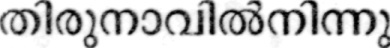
തിരുനാവില്‍നിന്നു
